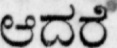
ಆದರೆ
